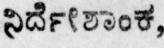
ನಿರ್ದೇಶಾಂಕ,
